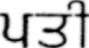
ਪਤੀ
